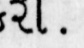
કરી.
